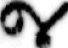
જ
